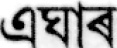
এঘাৰ
